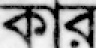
কার
